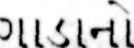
ગાડાનો
